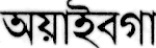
অয়াইবগা
